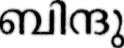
ബിന്ദു
